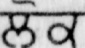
ਲੋਕ
